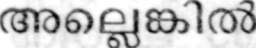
അല്ലെങ്കില്‍
